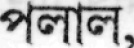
পলাল,
